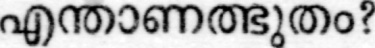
എന്താണത്ഭുതം?
